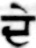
ਦੇ
